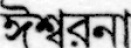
ঈশ্বরনা
